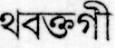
থবক্তগী
